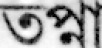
তপ্না
